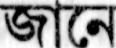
জানে
